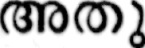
അതു
